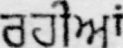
ਰਹੀਆਂ
